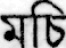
মচি
